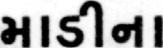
માડીના
